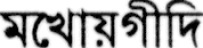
মখোয়গীদি
